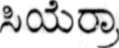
ಸಿಯೆರ್ರಾ
